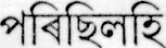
পৰিছিলহি
